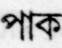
পাক
